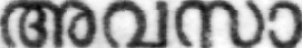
അവസാ
